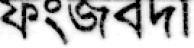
ফংজবদা
